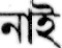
নাই
